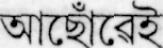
আছোঁৱেই
